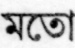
মতো
